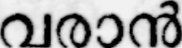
വരാന്‍
